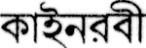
কাইনরবী
